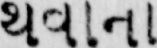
થવાના
